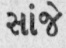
સાંજે
